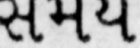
સમય
